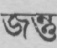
জন্তু
